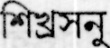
শিখ্রসনু
